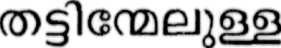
തട്ടിന്മേലുള്ള
